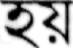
হয়
